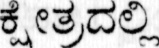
ಕ್ಷೇತ್ರದಲ್ಲಿ
